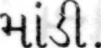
માંડી.
